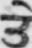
ਤੇ
